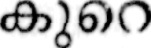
കുറെ
